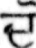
ਦੋ
